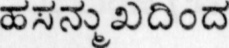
ಹಸನ್ಮುಖದಿಂದ
